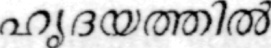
ഹൃദയത്തില്‍
